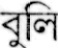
বুলি
